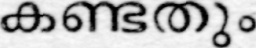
കണ്ടതും
